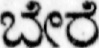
ಬೇರೆ
